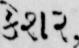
કેશર,
